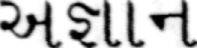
અજ્ઞાન
